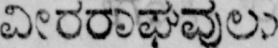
ವೀರರಾಘವುಲು
